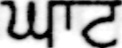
ਘਾਟ
